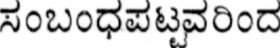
ಸಂಬಂಧಪಟ್ಟವರಿಂದ
